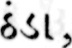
ઠંડા,
